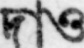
দাও
